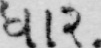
ધાર.
